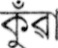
কুঁৱা
